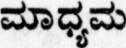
ಮಾಧ್ಯಮ
